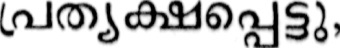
പ്രത്യക്ഷപ്പെട്ടു,
